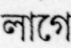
লাগে
